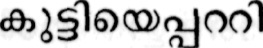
കുട്ടിയെപ്പററി
